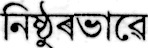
নিষ্ঠুৰভাৱে
